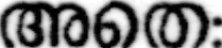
അതെ:
